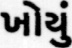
ખોયું
